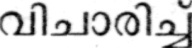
വിചാരിച്ച്
